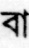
বা
